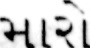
મારો
